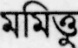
মমিত্তু
